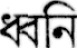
ধ্বনি
